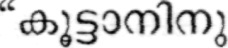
“കൂട്ടാനിനു
